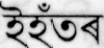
ইহঁতৰ
